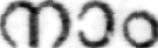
നാം
